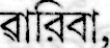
ৱারিবা,
